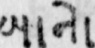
બાનો
